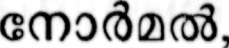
നോര്‍മല്‍,
